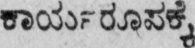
ಕಾರ್ಯರೂಪಕ್ಕೆ
